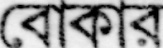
বোকার
